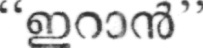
"ഇറാന്‍"
